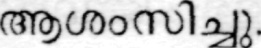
ആശംസിച്ചു.
